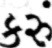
કરું
